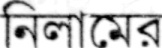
নিলামের
